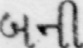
બની
